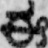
ಈ
